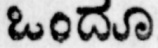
ಒಂದೂ
